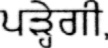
ਪੜ੍ਹੇਗੀ,
